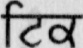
ਟਿਕ
